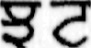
ਝਟ
